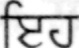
ਇਹ
